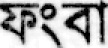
ফংবা
